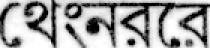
থেংনররে
